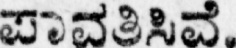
ಪಾವತಿಸಿವೆ.
